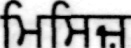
ਮਿਸਿਜ਼
